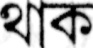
থাক
